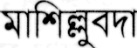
মাশিল্লুবদা
